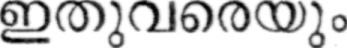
ഇതുവരെയും
